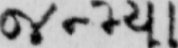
જન્મ્યા
